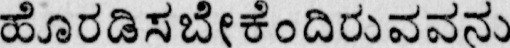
ಹೊರಡಿಸಬೇಕೆಂದಿರುವವನು
